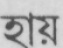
হায়
